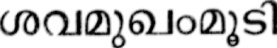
ശവമുഖംമൂടി
